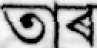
তাৰ
